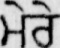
ਮੇਰੇ
